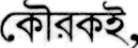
কৌরকই,
